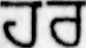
ਹਰ
